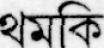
থমকি
